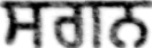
ਸਗਨ
